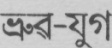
ভ্ৰুৱ-যুগ
